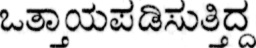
ಒತ್ತಾಯಪಡಿಸುತ್ತಿದ್ದ
